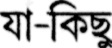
যা-কিছু
